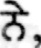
ਨੇ,
